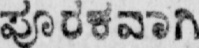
ಪೂರಕವಾಗಿ
